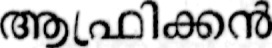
ആഫ്രിക്കന്‍
